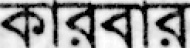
কারবার
